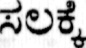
ಸಲಕ್ಕೆ
